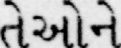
તેઓને
